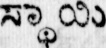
ಸ್ಥಾಯಿ
